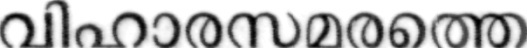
വിഹാരസമരത്തെ
